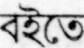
বইতে
